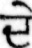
ਦੇ
